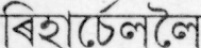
ৰিহার্চেললৈ
